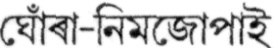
ঘোঁৰা-নিমজোপাই
